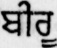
ਬੀਰੂ
